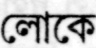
লোকে
